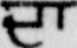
ਦਾ
